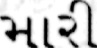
મારી
